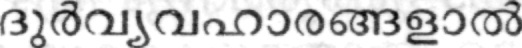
ദുര്‍വ്യവഹാരങ്ങളാല്‍
